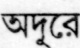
অদূরে
